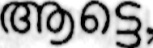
ആട്ടെ,
